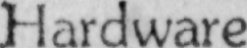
Hardware
